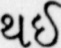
થઈ
